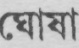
ঘোষা
